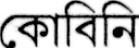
কোবিনি
